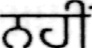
ਨਹੀਂ
